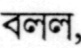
বলল,
